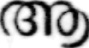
ആ
